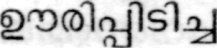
ഊരിപ്പിടിച്ച
